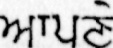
ਆਪਣੇ
